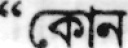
"কোন
